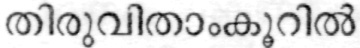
തിരുവിതാംകൂറില്‍
